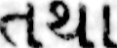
તથા
